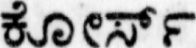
ಕೋರ್ಸ್
